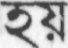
হয়
